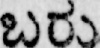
ಬರು
